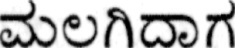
ಮಲಗಿದಾಗ
